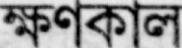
ক্ষণকাল
